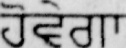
ਹੋਵੇਗਾ
